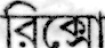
রিক্সো
